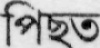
পিছত
